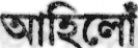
আহিলোঁ
